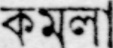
কমলা
